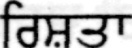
ਰਿਸ਼ਤਾ
